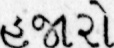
હજારો
